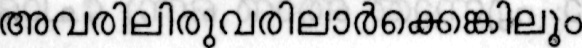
അവരിലിരുവരിലാര്‍ക്കെങ്കിലും
